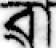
ৱা
